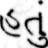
હતું
